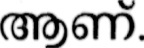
ആണ്.
